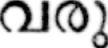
വരു
